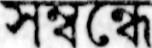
সম্বন্ধে
